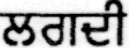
ਲਗਦੀ
